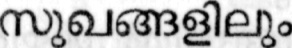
സുഖങ്ങളിലും
